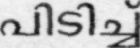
പിടിച്ച്
